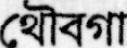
থৌবগা
